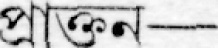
প্রাক্তন-
